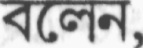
বলেন,
